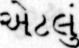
એટલું
